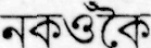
নকওঁকৈ
